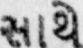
સાથે
